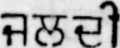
ਜਲਦੀ
